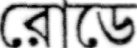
রোডে
